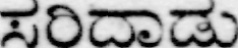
ಸರಿದಾಡು
